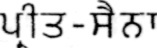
ਪ੍ਰੀਤ-ਸੈਨਾ
